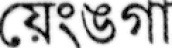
য়েংঙগা
